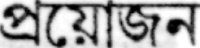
প্রয়োজন
